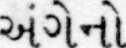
અંગેનો
